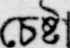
চেষ্টা
